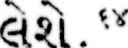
લેશે.૬૪
